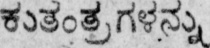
ಕುತಂತ್ರಗಳನ್ನು
